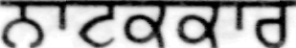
ਨਾਟਕਕਾਰ
